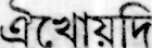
ঐখোয়দি
